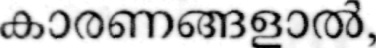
കാരണങ്ങളാല്‍,
